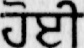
ਹੋਈ
